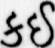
કઈ
